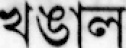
খঙাল
